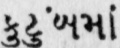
કુટુંબમાં
